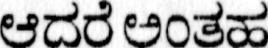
ಆದರೆಅಂತಹ
